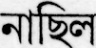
নাছিল
